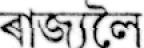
ৰাজ্যলৈ
